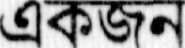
একজন
